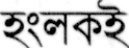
হংলকই
